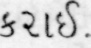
કરાઈ.
